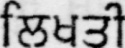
ਲਿਖਤੀ
